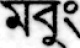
মবুং
